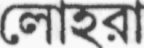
লোহরা
